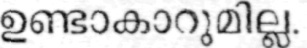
ഉണ്ടാകാറുമില്ല.
